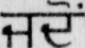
ਜਦੋਂ
